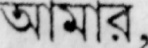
আমার,
